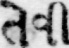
તેવી
